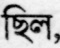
ছিল,
